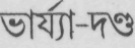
ভাৰ্য্যা-দণ্ড
